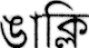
ঙাক্লি
